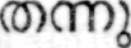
തന്നു
